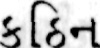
કઠિન
